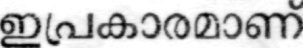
ഇപ്രകാരമാണ്
